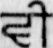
ਵੀ
